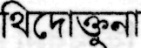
থিদোক্তুনা
